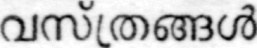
വസ്ത്രങ്ങള്‍
